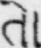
તો
